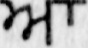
ਆ
